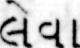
લેવા
